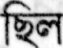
ছিল
